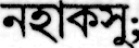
নহাকসু;
